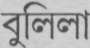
বুলিলা
